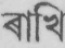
ৰাখি
